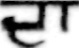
ਦਾ
